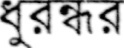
ধুরন্ধর
